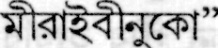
মীরাইবীনুকো”
